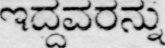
ಇದ್ದವರನ್ನು
